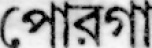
পোরগা
